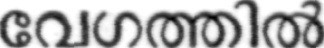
വേഗത്തില്‍
